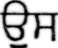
ਉਸ
